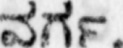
ವರ್ಗ.
